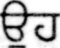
ਉਹ
